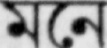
মনে
